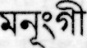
মনূংগী
